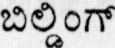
ಬಿಲ್ಡಿಂಗ್
